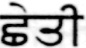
ਛੇਤੀ
